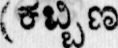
(ಕಬ್ಬಿಣ
